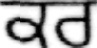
ਕਰ
